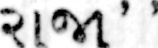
રાજા"
